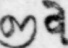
જીવે
